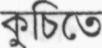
কুচিতে
